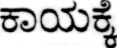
ಕಾಯಕ್ಕೆ
